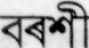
বৰশী
